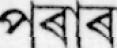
পৰাৰ
